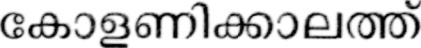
കോളണിക്കാലത്ത്
